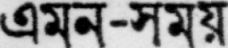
এমন-সময়
